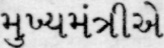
મુખ્યમંત્રીએ
